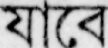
যাবে
